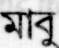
মাবু
